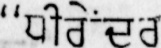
''ਧੀਰੇਂਦਰ
